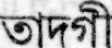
তাদগী
